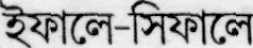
ইফালে-সিফালে
